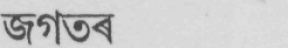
জগতৰ
